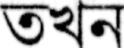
তখন
